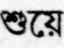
শুয়ে
